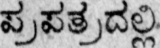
ಪ್ರಪತ್ರದಲ್ಲಿ
